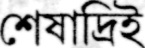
শেষাদ্রিই
